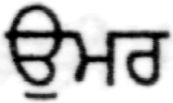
ਉਮਰ
